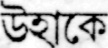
উহাকে
